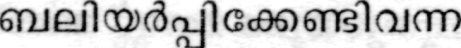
ബലിയര്‍പ്പിക്കേണ്ടിവന്ന
